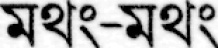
মথং-মথং
